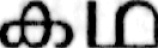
കഥ
